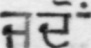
ਜਦੋਂ
